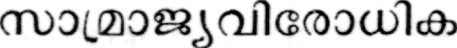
സാമ്രാജ്യവിരോധിക
